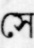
সে
